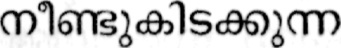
നീണ്ടുകിടക്കുന്ന
